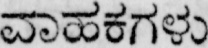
ವಾಹಕಗಳು
